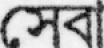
সেবা
